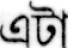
এটা
